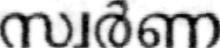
സ്വര്‍ണ
